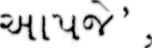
આપજે,
